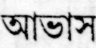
আভাস
